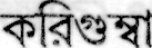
করিগুম্বা
